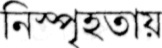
নিস্পৃহতায়
